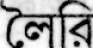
লৈরি
